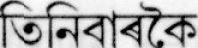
তিনিবাৰকৈ
